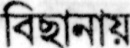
বিছানায়
